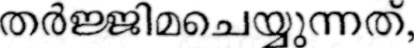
തര്‍ജ്ജിമചെയ്യുന്നത്,
